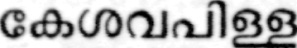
കേശവപിള്ള
